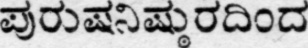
ಪುರುಷನಿಷ್ಠುರದಿಂದ
